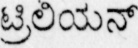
ಟ್ರಿಲಿಯನ್
